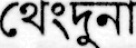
থেংদুনা
